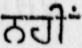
ਨਹੀਂ
